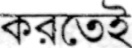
করতেই
